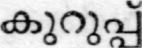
കുറുപ്പ്
